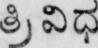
ತ್ರಿವಿಧ
